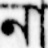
না
